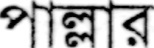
পাল্লার
